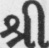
શ્રી
